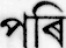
পৰি
